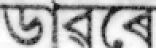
ডাৱৰে
